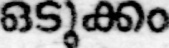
ഒടുക്കം
